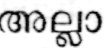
അല്ലാ
